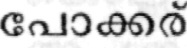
പോക്കര്
